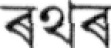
ৰথৰ
